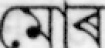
মোৰ
